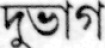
দুভাগ
